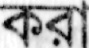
করা
